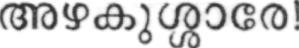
അഴകുശ്ശാരേ!
